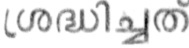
ശ്രദ്ധിച്ചത്
